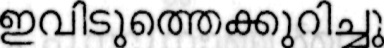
ഇവിടുത്തെക്കുറിച്ചു
